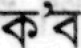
ক'ব
